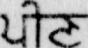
ਪੀਣ
